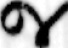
જ
